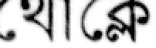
থোক্লে
